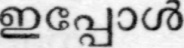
ഇപ്പോള്‍
